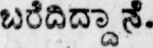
ಬರೆದಿದ್ದಾನೆ.
